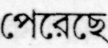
পেরেছে
